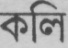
কলি
